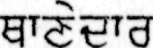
ਥਾਣੇਦਾਰ
